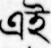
এই
